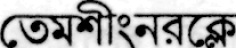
তেমশীংনরক্লে
